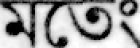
মতেং
